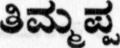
ತಿಮ್ಮಪ್ಪ
